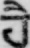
ਹੈ
